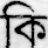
কি
